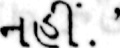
નહીં.'
